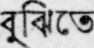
বুঝিতে
